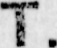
T.
